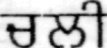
ਚਲੀ
